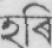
হৰি
